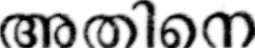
അതിനെ
